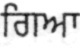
ਗਿਆ
